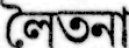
লৈতনা
